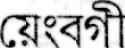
য়েংবগী
